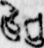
હેતુ
